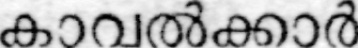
കാവല്‍ക്കാര്‍
